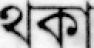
থকা
